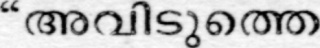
"അവിടുത്തെ
